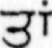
ਤਾਂ
